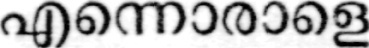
എന്നൊരാളെ
